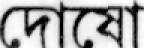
দোষো
